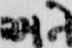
અને
